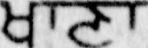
ਖਾਣਾ
